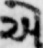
એ
